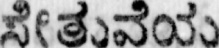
ಸೇತುವೆಯ
